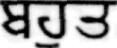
ਬਹੁਤ
